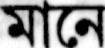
মানে
